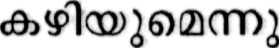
കഴിയുമെന്നു
